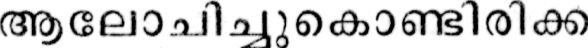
ആലോചിച്ചുകൊണ്ടിരിക്ക
